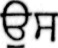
ਉਸ
